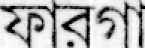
ফারগা
